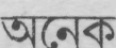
অনেক
